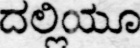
ದಲ್ಲಿಯೂ
